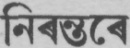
নিৰন্তৰে
